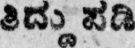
ತಿದ್ದುಪಡಿ
